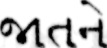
જાતને
